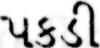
પકડી
